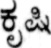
ಕೃಷಿ
